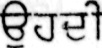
ਉਹਦੀ
